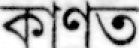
কাণত
